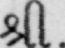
શ્રી.
